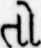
તો
